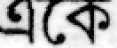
একে
